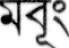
মবূং
